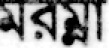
মরম্না
